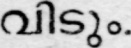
വിടും.
